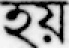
হয়
